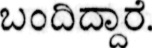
ಬಂದಿದ್ದಾರೆ.
